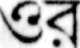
ওর
